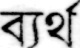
ব্যর্থ
